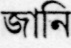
জানি
